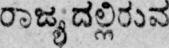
ರಾಜ್ಯದಲ್ಲಿರುವ
